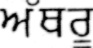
ਅੱਥਰੂ
